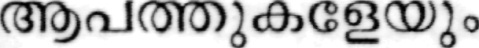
ആപത്തുകളേയും
